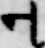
ન
